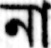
না
